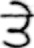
ਤੇ
